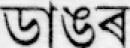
ডাঙৰ
